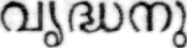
വൃദ്ധനു
